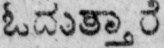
ಓದುತ್ತಾರೆ
